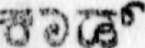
ಕಾಡ್
